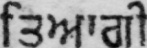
ਤਿਆਗੀ
